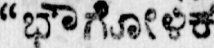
“ಭೌಗೋಳಿಕ
